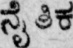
ನೈತಿಕ
